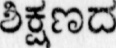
ಶಿಕ್ಷಣದ
